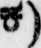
ಕ)
